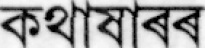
কথাষাৰৰ
